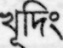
খূদিং
